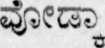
ವೋಡ್ಕಾ
